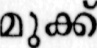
മുക്ക്
